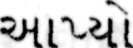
આપ્યો
